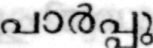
പാര്‍പ്പു
